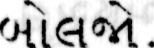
બોલજો.
